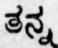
ತನ್ನ
